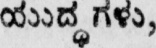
ಯುದ್ಧಗಳು,
